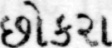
છોકરા
